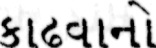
કાઢવાનો
